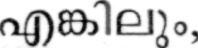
എങ്കിലും,
